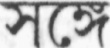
সঙ্গে
